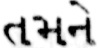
તમને
